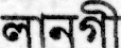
লানগী
